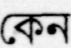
কেন
